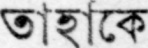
তাহাকে
